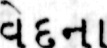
વેદના
